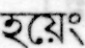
হয়েং
